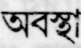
অবস্থা
